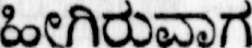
ಹೀಗಿರುವಾಗ
